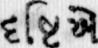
દષ્ટિએ
